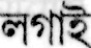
লগাই
